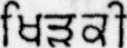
ਖਿੜਕੀ
